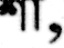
শা,
